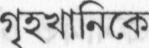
গৃহখানিকে
